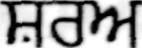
ਸ਼ਰਅ
